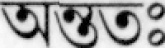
অন্ততঃ
